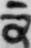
ਕੇ
